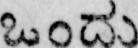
ಒಂದು
